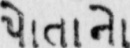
પોતાનો
